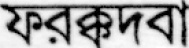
ফরক্কদবা
